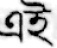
এই
